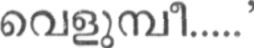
വെളുമ്പീ....’
